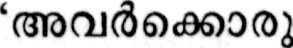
‘അവര്‍ക്കൊരു
